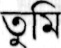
তুমি
